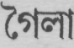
গৈলা
